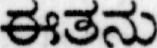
ಈತನು
